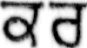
ਕਰ
